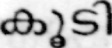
കൂടി
